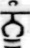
ਨੂੰ
